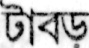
টাবড়
